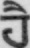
ਹੈ
